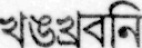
খঙখ্রবনি
